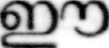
ഈ
